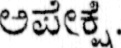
ಅಪೇಕ್ಷೆ.
